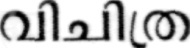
വിചിത്ര
